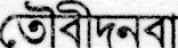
তৌবীদনবা
